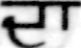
ਦਾ
